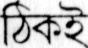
ঠিকই
